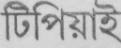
টিপিয়াই
